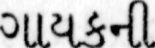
ગાયકની
